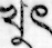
খুৎ
